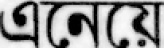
এনেয়ে
